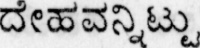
ದೇಹವನ್ನಿಟ್ಟು
